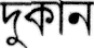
দুকান
